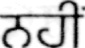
ਨਹੀਂ
